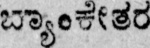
ಬ್ಯಾಂಕೇತರ
